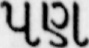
પણ
